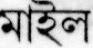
মাইল
